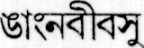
ঙাংনবীবসু
